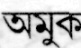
অমুক
